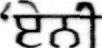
'ਏਨੀ
